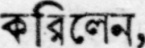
করিলেন,
